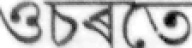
ওচৰতে
